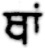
ਥਾਂ
